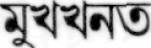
মুখখনত
